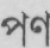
পণ
